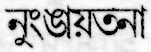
নুংঙায়তনা
